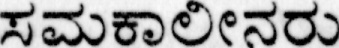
ಸಮಕಾಲೀನರು
